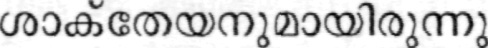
ശാക്തേയനുമായിരുന്നു
